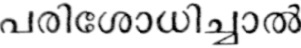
പരിശോധിച്ചാല്‍
